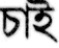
চাই
